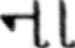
ના
